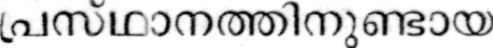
പ്രസ്ഥാനത്തിനുണ്ടായ
